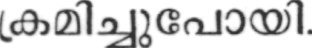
ക്രമിച്ചുപോയി.
